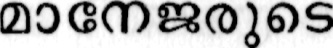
മാനേജരുടെ
